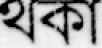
থকা
